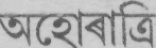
অহোৰাত্ৰি
